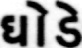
ઘોડે
